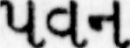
પવન
